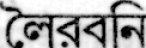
লৈরবনি
